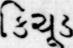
કિચૂડ
